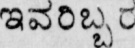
ಇವರಿಬ್ಬರ
